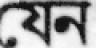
যেন
